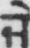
ਜੇ
